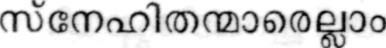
സ്നേഹിതന്മാരെല്ലാം
